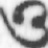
ও
